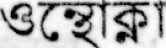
ওন্থোক্না
